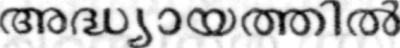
അദ്ധ്യായത്തില്‍
